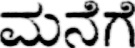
ಮನೆಗೆ
